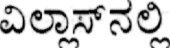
ವಿಲ್ಲಾಸ್ನಲ್ಲಿ
